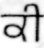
ਕੀ
